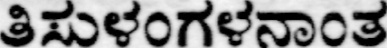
ತಿಸುಳಂಗಳನಾಂತ
